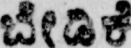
ಬೇಡಿಕೆ
